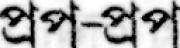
প্রপ-প্রপ
